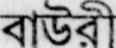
বাউরী
